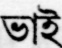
ভাই
